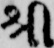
શ્રી
